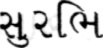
સુરભિ
